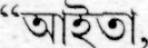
"আইতা,
